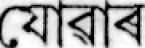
যোৱাৰ
